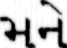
મને
